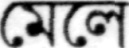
মেলে
